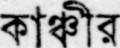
কাঞ্চীর
